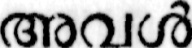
അവള്‍
